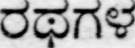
ರಥಗಳ
